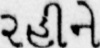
રહીને
